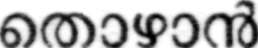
തൊഴാന്‍
